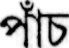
পাঁচ
